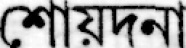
শোয়দনা
